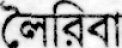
লৈরিবা
